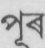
পূৰ
